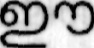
ഈ
